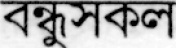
বন্ধুসকল
